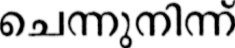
ചെന്നുനിന്ന്
